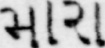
મારા
